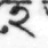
হে
